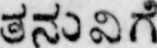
ತನುವಿಗೆ
